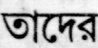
তাদের
